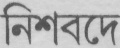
নিশবদে
